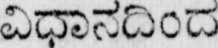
ವಿಧಾನದಿಂದ
